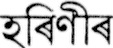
হৰিণীৰ
